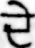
ਦੇ
